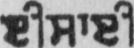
ਈਸਾਈ
